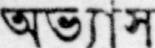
অভ্যাস
